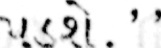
પડશે."
